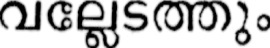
വല്ലേടത്തും
